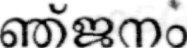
ഞ്ജനം
